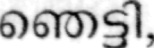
ഞെട്ടി,
